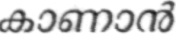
കാണാന്‍
